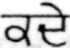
ਕਦੇ
